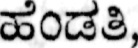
ಹೆಂಡತಿ,
